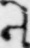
ને
